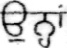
ਉਨ੍ਹਾਂ
